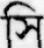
সি
